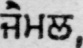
ਜੈਮਲ,
